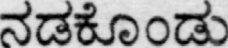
ನಡಕೊಂಡು
